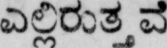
ಎಲ್ಲಿರುತ್ತವೆ
